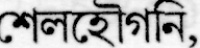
শেলহৌগনি,
